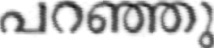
പറഞ്ഞു
